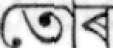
তোৰ
